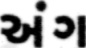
અંગ
